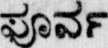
ಪೂರ್ವ
